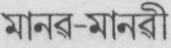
মানৱ-মানৱী
